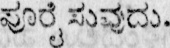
ಪೂರೈಸುವುದು.
